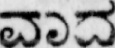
ವಾದ
